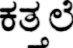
ಕತ್ತಲೆ
